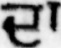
ਦਾ
